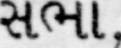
સભા,
